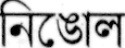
নিঙোল
